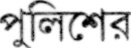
পুলিশের
